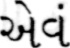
એવં
